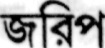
জরিপ
